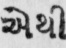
એથી
